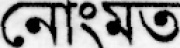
নোংমত
